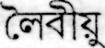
লৈবীয়ু
